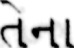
તેના
